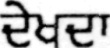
ਦੇਖਦਾ
